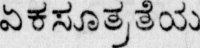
ಏಕಸೂತ್ರತೆಯ
